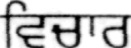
ਵਿਚਾਰ
